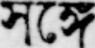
সঙ্গে
